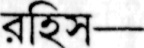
রহিস–
